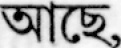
আছে,
